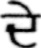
ਦੇ
